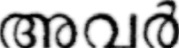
അവര്‍
